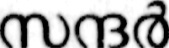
സന്ദര്‍
